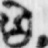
છે.
